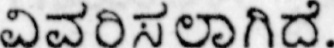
ವಿವರಿಸಲಾಗಿದೆ.
